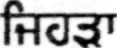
ਜਿਹੜਾ
